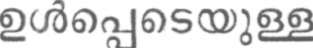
ഉള്‍പ്പെടെയുള്ള
